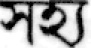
সহ্য
